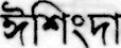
ঈশিংদা
